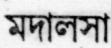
মদালসা
